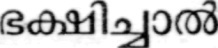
ഭക്ഷിച്ചാല്‍
